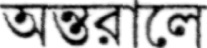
অন্তরালে
